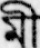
মী
